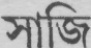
সাজি
